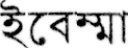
ইবেম্মা
